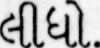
લીધો.
